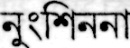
নুংশিননা
